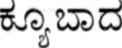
ಕ್ಯೂಬಾದ
